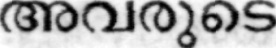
അവരുടെ
